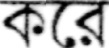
করে
